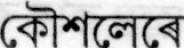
কৌশলেৰে
